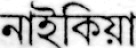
নাইকিয়া
